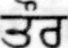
ਤੌਰ
